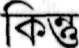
কিন্তু
